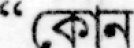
"কোন
